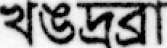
খঙদ্রব্রা
